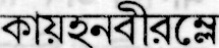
কায়হনবীরম্লে
